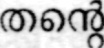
തന്റെ
